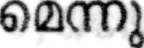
മെന്നു
